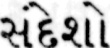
સંદેશો
